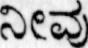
ನೀವು
